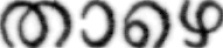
താഴെ
